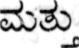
ಮತ್ತು
